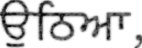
ਉਠਿਆ,
